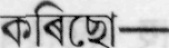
কৰিছো-
